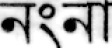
নংনা
